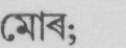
মোৰ;
